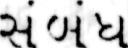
સંબંધ
